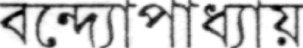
বন্দ্যোপাধ্যায়
